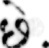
ચે.
